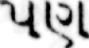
પણ
